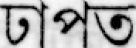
ঢাপত
